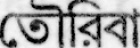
তৌরিবা
